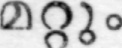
മറ്റും
